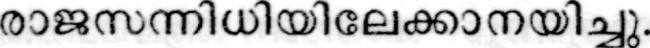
രാജസന്നിധിയിലേക്കാനയിച്ചു.
